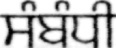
ਸੰਬੰਧੀ
